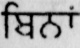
ਬਿਨਾਂ
